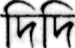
দিদি
